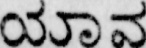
ಯಾವ
